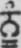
ਨੂੰ
